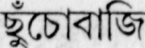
ছুঁচোবাজি
